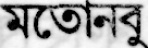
মতোনবু
